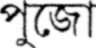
পুজো
